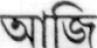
আজি
